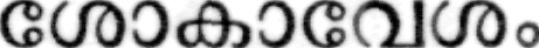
ശോകാവേശം
